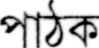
পাঠক
